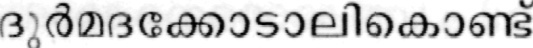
ദുര്‍മദക്കോടാലികൊണ്ട്
